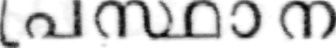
പ്രസ്ഥാന
